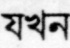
যখন
